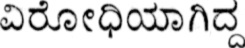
ವಿರೋಧಿಯಾಗಿದ್ದ
